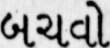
બચવો
